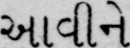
આવીને
